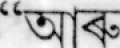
"আৰু
